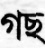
গছ
